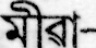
মীৱা-
